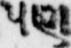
પણ
